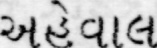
અહેવાલ
